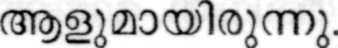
ആളുമായിരുന്നു.
